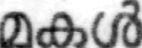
മകള്‍
